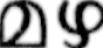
മഴ
